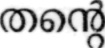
തന്റെ
